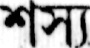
শস্য
